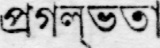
প্রগল্‌ভতা
